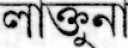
লাক্তুনা
